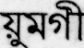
য়ুমগী
